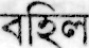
বহিল
